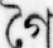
গৈ
